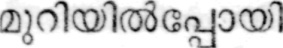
മുറിയില്‍പ്പോയി
